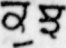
ਕੁਝ
